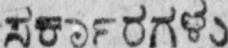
ಸರ್ಕಾರಗಳು
